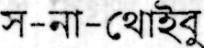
স-না-থোইবু
